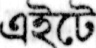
এইটে
